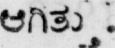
ಆಗಿತ್ತು.
